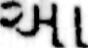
આ
